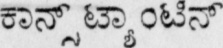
ಕಾನ್ಸ್ ಟ್ಯಾಂಟಿನ್
